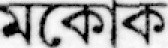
মকোক
